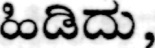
ಹಿಡಿದು,
